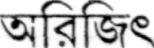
অরিজিৎ
